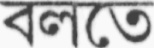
বলতে
